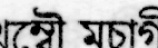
লৈশেম্বগী
